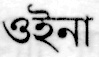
ওইনা
